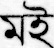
মই
